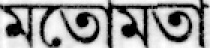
মতোমতা
